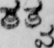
ತತ್ವ
